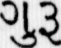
ગુરૂ
